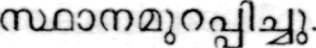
സ്ഥാനമുറപ്പിച്ചു.
